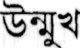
উন্মুখ
